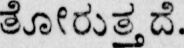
ತೋರುತ್ತದೆ.
